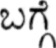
ಬಗ್ಗೆ
